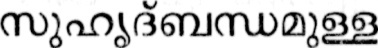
സുഹൃദ്ബന്ധമുള്ള
